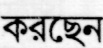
করছেন
